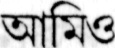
আমিও
